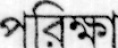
পরিক্ষা
